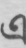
এ
